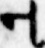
ન
